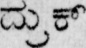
ದ್ರುಕ್
